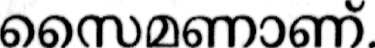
സൈമണാണ്.
